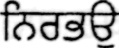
ਨਿਰਭਉ
